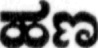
ಹಣ
